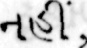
નહીં,
